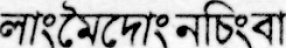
লাংমৈদোংনচিংবা
